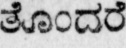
ತೊಂದರೆ
